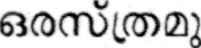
ഒരസ്ത്രമു
